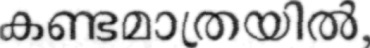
കണ്ടമാത്രയില്‍,
